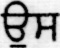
ਉਸ
